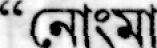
“নোংমা
